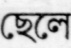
ছেলে
